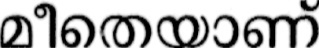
മീതെയാണ്
